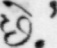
છે.'
